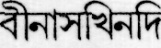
বীনাসখিনদি
